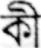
কী
